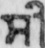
ਸੀ
